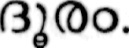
ദൂരം.
